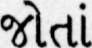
જોતાં
